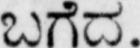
ಬಗೆದ.
